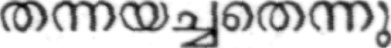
തന്നയച്ചതെന്നു
